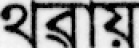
থৱায়
